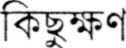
কিছুক্ষণ
